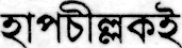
হাপচীল্লকই
